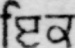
ਇਕ
